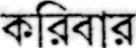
করিবার
